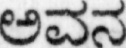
ಅವನ
